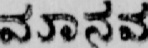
ಮಾನವ
